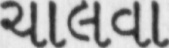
ચાલવા
